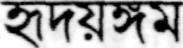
হৃদয়ঙ্গম
